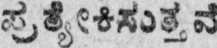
ಪ್ರತ್ಯೇಕಿಸುತ್ತವೆ
